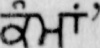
ਕੰਮਾਂ'
